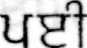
ਪਈ
